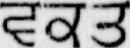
ਵਕਤ
